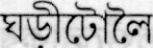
ঘড়ীটোলৈ
